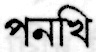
পনখি
